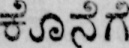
ಕೊನೆಗೆ
